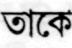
তাকে
